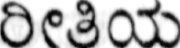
ರೀತಿಯ
